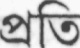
প্রতি
